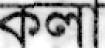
কলা
